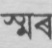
স্মৰ
